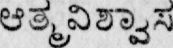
ಆತ್ಮವಿಶ್ವಾಸ
